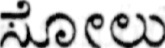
ಸೋಲು
